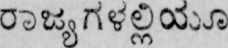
ರಾಜ್ಯಗಳಲ್ಲಿಯೂ
